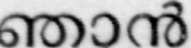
ഞാന്‍
